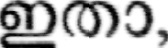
ഇതാ,
